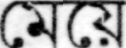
মেয়ে
